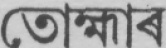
তোহ্মাৰ
